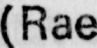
(Rae
